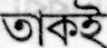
তাকই
